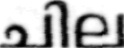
ചില
